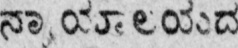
ನ್ಯಾಯಾಲಯದ
